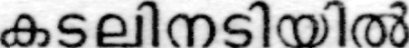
കടലിനടിയില്‍
